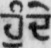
ਹੁੰਦੇ
